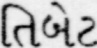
તિબેટ
